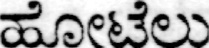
ಹೋಟೆಲು
